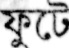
ফুটে
